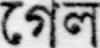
গেল
